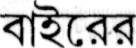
বাইরের
